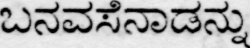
ಬನವಸೆನಾಡನ್ನು
